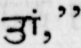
ਤਾਂ,''
